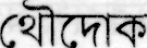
থৌদোক
